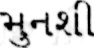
મુનશી
